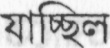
যাচ্ছিল
